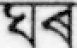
ঘৰ
